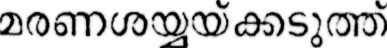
മരണശയ്യയ്ക്കടുത്ത്
